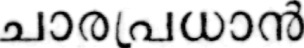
ചാരപ്രധാന്‍
